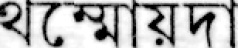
থম্মোয়দা
